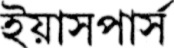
ইয়াসপার্স
